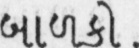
બાળકો.
